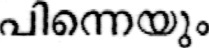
പിന്നെയും
